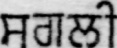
ਸਗਲੀ
